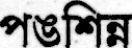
পঙশিন্ন
